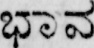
ಭಾವ
